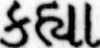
કહ્યા
